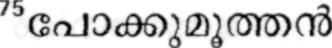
75പോക്കുമൂത്തന്‍
